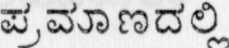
ಪ್ರಮಾಣದಲ್ಲಿ
